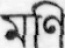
মণি
